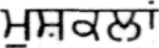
ਮੁਸ਼ਕਲਾਂ
